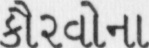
કૌરવોના
